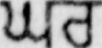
ਘਰ
